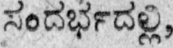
ಸಂದರ್ಭದಲ್ಲಿ,
